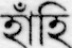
হাঁহি
